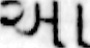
આ
